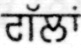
ਗੱਲਾਂ
